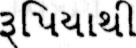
રૂપિયાથી
